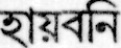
হায়বনি
